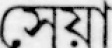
সেয়া
